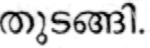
തുടങ്ങി.
